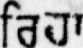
ਰਿਹਾ
